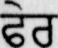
ਫੇਰ
